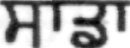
ਸਾਡਾ
